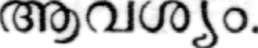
ആവശ്യം.
